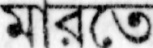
মারতে
